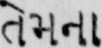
તેમના
